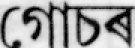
গোচৰ
